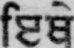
ਇਥੇ
